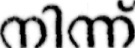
നിന്ന്
